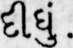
દીધું.
